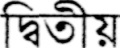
দ্বিতীয়
